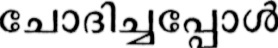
ചോദിച്ചപ്പോള്‍
